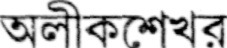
অলীকশেখর
